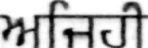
ਅਜਿਹੀ
